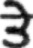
ਤੇ
